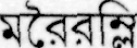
মরৈরম্লি
